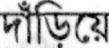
দাঁড়িয়ে
